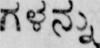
ಗಳನ್ನು
